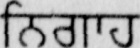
ਨਿਗਾਹ
